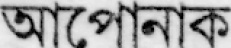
আপোনাক
